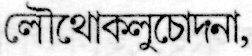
লৌথোকলুচোদনা,
